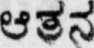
ಆತನ
